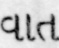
વાત
